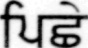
ਪਿਛੇ
